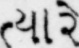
ત્યારે
